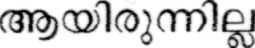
ആയിരുന്നില്ല
